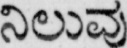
ನಿಲುವು
